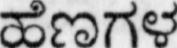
ಹೆಣಗಳ
